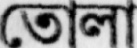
তোলা
